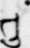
તું
